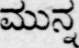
ಮುನ್ನ
